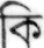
কি
